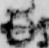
ಈ
